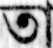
তা
